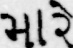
મારે
